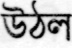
উঠল
